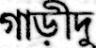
গাড়ীদু
